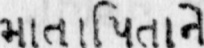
માતાપિતાને
